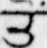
ਤੋਂ
